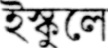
ইস্কুলে
